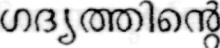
ഗദ്യത്തിന്റെ
